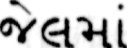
જેલમાં
